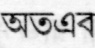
অতএব
